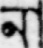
না
